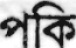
পকি
